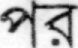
পর
